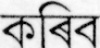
কৰিব
